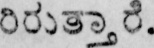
ರಿರುತ್ತಾರೆ.
